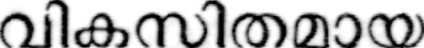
വികസിതമായ
